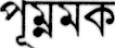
পূম্নমক
